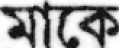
মাকে
